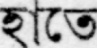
হাতে
